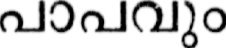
പാപവും
